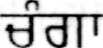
ਚੰਗਾ
